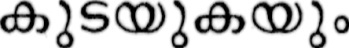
കുടയുകയും
